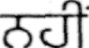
ਨਹੀਂ
